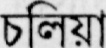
চলিয়া
